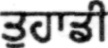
ਤੁਹਾਡੀ
